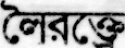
লৈরক্ত্রে
